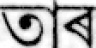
তাৰ
